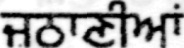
ਜਠਾਣੀਆਂ
